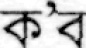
ক'ব
